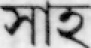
সাহ
